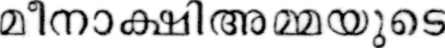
മീനാക്ഷിഅമ്മയുടെ
